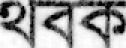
থবক
